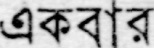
একবার
